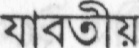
যাবতীয়
